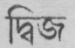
দ্বিজ
